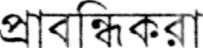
প্রাবন্ধিকরা
